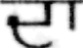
ਦਾ
